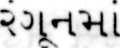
રંગૂનમાં
